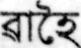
ৱাহৈ
